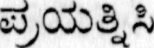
ಪ್ರಯತ್ನಿಸಿ
